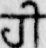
ਹੀ
